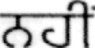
ਨਹੀਂ
